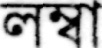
লম্বা
